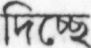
দিচ্ছে
